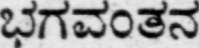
ಭಗವಂತನ
